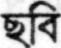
ছবি
